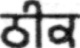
ਠੀਕ
